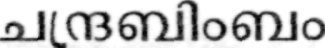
ചന്ദ്രബിംബം
